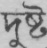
দুষ্ট
